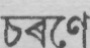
চৰণে
